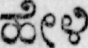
ಹೇಳಿ
